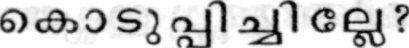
കൊടുപ്പിച്ചില്ലേ?
